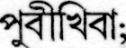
পুবীখিবা;
